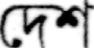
দেশ
